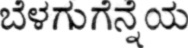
ಬೆಳಗುಗೆನ್ನೆಯ
